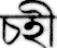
চহী
